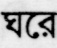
ঘরে
